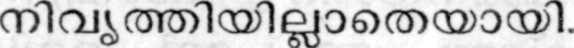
നിവൃത്തിയില്ലാതെയായി.
